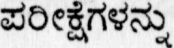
ಪರೀಕ್ಷೆಗಳನ್ನು
